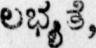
ಲಭ್ಯತೆ,
